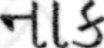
નાક
